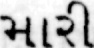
મારી
